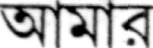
আমার
